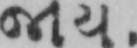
જાય.
